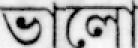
ভালো
